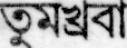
তুমখ্রবা
